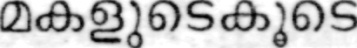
മകളുടെകൂടെ
